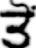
ਤੋਂ
